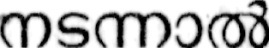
നടന്നാല്‍
